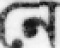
নে
